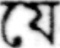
যে
